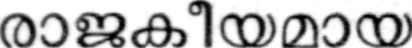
രാജകീയമായ
